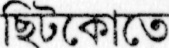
ছিটকোতে
